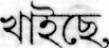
খাইছে,
